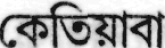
কেতিয়াবা
